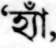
‘হ্যাঁ,
